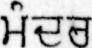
ਮੰਦਰ
